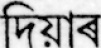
দিয়াৰ
